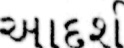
આદર્શ
